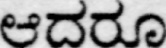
ಆದರೂ
